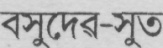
বসুদেৱ-সুত
